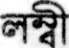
লম্বী
